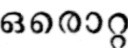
ഒരൊറ്റ
